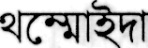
থম্মোইদা
